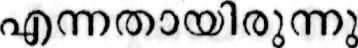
എന്നതായിരുന്നു
